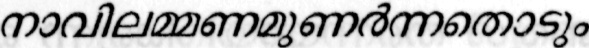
നാവിലമ്മണമുണര്‍ന്നതൊടും
